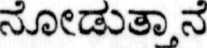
ನೋಡುತ್ತಾನೆ
